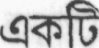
একটি
